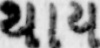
થાય
